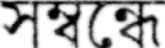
সম্বন্ধে
